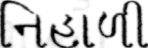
નિહાળી
